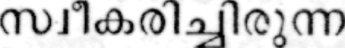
സ്വീകരിച്ചിരുന്ന
